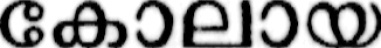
കോലായ
